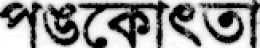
পঙকোৎতা
